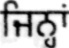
ਜਿਨ੍ਹਾਂ
